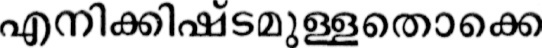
എനിക്കിഷ്ടമുള്ളതൊക്കെ
